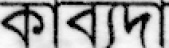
কাব্যাদা
